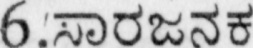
6.ಸಾರಜನಕ
